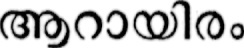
ആറായിരം
